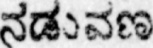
ನಡುವಣ
